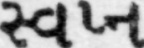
સ્વપ્ન
